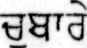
ਚੁਬਾਰੇ
